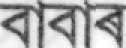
বাবাৰ
